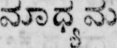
ಮಾಧ್ಯಮ
